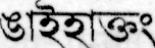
ঙাইহাক্তং
